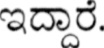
ಇದ್ದಾರೆ.
